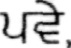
ਪਵੇ,
